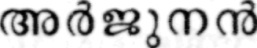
അര്‍ജുനന്‍
